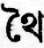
থৈ
